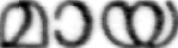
മായ
